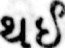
થઈ
